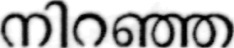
നിറഞ്ഞ
